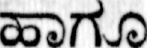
ಹಾಗೂ
